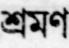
শ্রমণ
